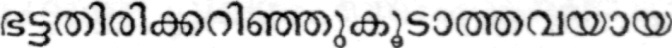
ഭട്ടതിരിക്കറിഞ്ഞുകൂടാത്തവയായ
